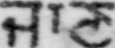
ਜਾਣ
